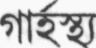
গার্হস্থ্য
